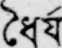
ধৈর্য
